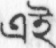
এই
